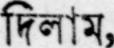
দিলাম,
